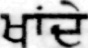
ਖਾਂਦੇ
